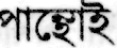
পান্থোই
